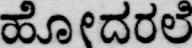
ಹೋದರಲೆ
